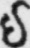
ઈ
